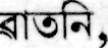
ৱাতনি,
